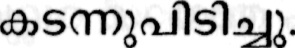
കടന്നുപിടിച്ചു.
